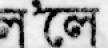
ল'লে
